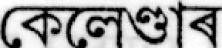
কেলেণ্ডাৰ
